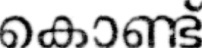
കൊണ്ട്
